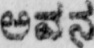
ಅವನ
